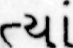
ત્યાં
